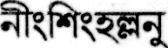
নীংশিংহল্লনু
